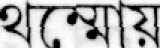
থম্মোয়
